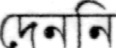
দেননি
